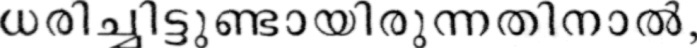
ധരിച്ചിട്ടുണ്ടായിരുന്നതിനാല്‍,
